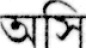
অসি
